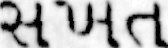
સખત
